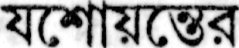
যশোয়ন্তের
